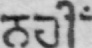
ਨਹੀਂ
